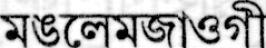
মঙলেমজাওগী
